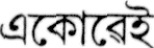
একোৱেই
